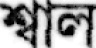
শ্বাল
